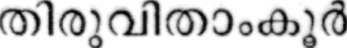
തിരുവിതാംകൂര്‍
